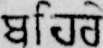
ਬਹਿਰੇ
